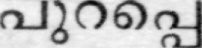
പുറപ്പെ
